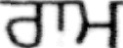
ਰਾਮ
